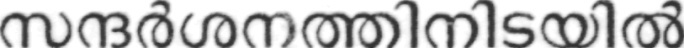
സന്ദര്‍ശനത്തിനിടയില്‍
